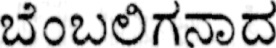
ಬೆಂಬಲಿಗನಾದ
